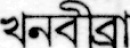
খনবীব্রা
